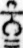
ਨੂੰ
